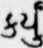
કર્યું
